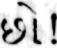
છો!
